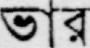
ভার
